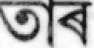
তাৰ
